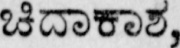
ಚಿದಾಕಾಶ,
